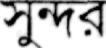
সুন্দর
